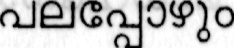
പലപ്പോഴും
